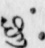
છું.
